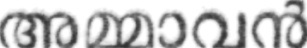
അമ്മാവന്‍
